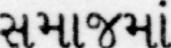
સમાજમાં
